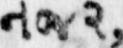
નજર
